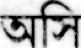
অসি
